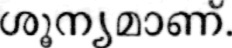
ശൂന്യമാണ്.
